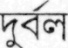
দুর্বল
